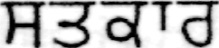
ਸਤਕਾਰ
